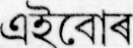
এইবোৰ
